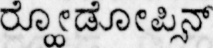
ರ್‍ಹೋಡೋಪ್ಸಿನ್
